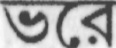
ভরে
